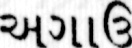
અગાઉ
